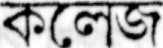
কলেজ
